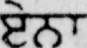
ਏਨਾ
